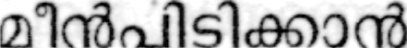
മീന്‍പിടിക്കാന്‍
